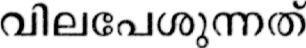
വിലപേശുന്നത്
